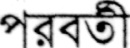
পরবর্তী
